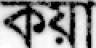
কয়া
